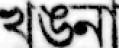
খঙনা
